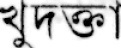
খুদক্তা
